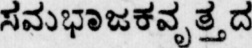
ಸಮಭಾಜಕವೃತ್ತದ
